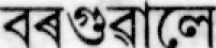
বৰগুৱালে
